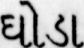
ઘોડા
